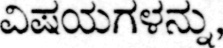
ವಿಷಯಗಳನ್ನು,
